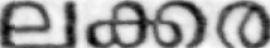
ലക്കര
